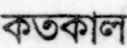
কতকাল
